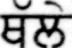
ਥੱਲੇ
